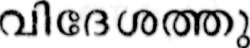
വിദേശത്തു
